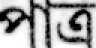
পাত্র
